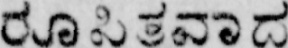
ರೂಪಿತವಾದ
